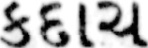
કદાચ
